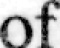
of
